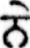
ਨੇ
